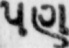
પણ
